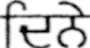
ਦਿਨੇ
